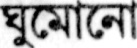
ঘুমোনো
